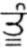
ਤੂੰ
